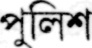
পুলিশ
